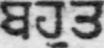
ਬਹੁਤ
